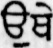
ਉਥੇ
